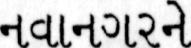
નવાનગરને
